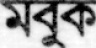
মবুক
